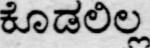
ಕೊಡಲಿಲ್ಲ
